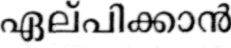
ഏല്പിക്കാന്‍
